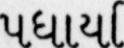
પધાર્યા
